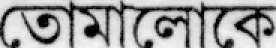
তোমালোকে
